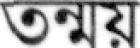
তন্ময়
